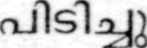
പിടിച്ചു
